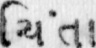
ચિંતા
